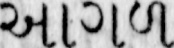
આગળ
